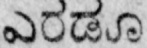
ಎರಡೂ
